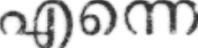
എന്നെ
